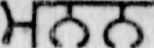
ਮਨਨ
